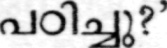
പഠിച്ചു?’
